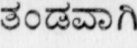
ತಂಡವಾಗಿ
